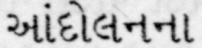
આંદોલનના
